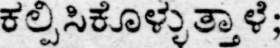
ಕಲ್ಪಿಸಿಕೊಳ್ಳುತ್ತಾಳೆ;
